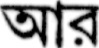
আর
